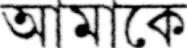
আমাকে
